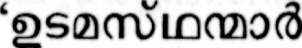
‘ഉടമസ്ഥന്മാര്‍
